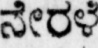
ನೇರಳೆ
